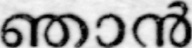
ഞാന്‍
